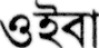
ওইবা
